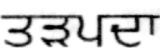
ਤੜਪਦਾ
